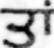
ਤਾਂ
